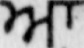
ਆ
